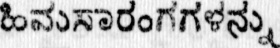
ಹಿಮಸಾರಂಗಗಳನ್ನು
